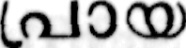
പ്രായ
